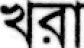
খরা
